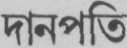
দানপতি
